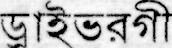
ড্রাইভরগী
